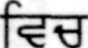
ਵਿਚ
